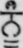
ਨੂੰ
